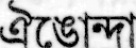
ঐঙোন্দা
